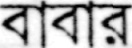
বাবার
